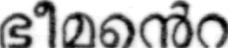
ഭീമന്റെ
